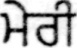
ਮੇਰੀ
